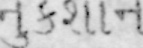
નુકશાન
